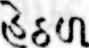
હેઠળ
